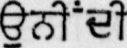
ਉਨੀਂਦੀ
